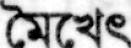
মৈখেৎ
